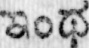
ಇಂಥ
